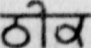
ਠੀਕ
